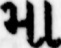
મા
